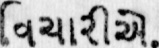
વિચારીએ.
